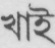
খাই
